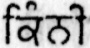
ਕਿੰਨੀ
